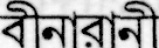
বীনারানী
